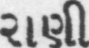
રાણી
